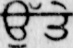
ਉੱਤੇ
